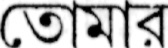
তোমার
